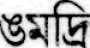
ঙমদ্রি
